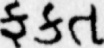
ફકત
